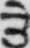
ਤੇ
